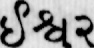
ઈશ્વર
